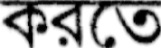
করতে
